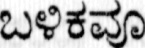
ಬಳಿಕವೂ
